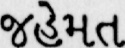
જહેમત
